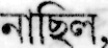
নাছিল,
